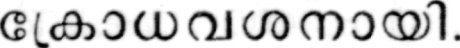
ക്രോധവശനായി.
